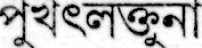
পুখৎলক্তুনা
